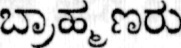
ಬ್ರಾಹ್ಮಣರು
